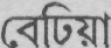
বেঢ়িয়া
